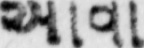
આવા
